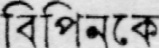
বিপিনকে
